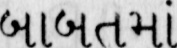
બાબતમાં
